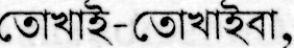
তোখাই-তোখাইবা,
